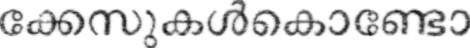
ക്കേസുകള്‍കൊണ്ടോ
